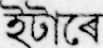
ইটাৰে
